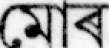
মোৰ
